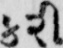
કરી
